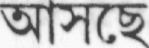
আসছে
